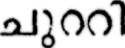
ചുററി
